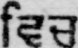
ਵਿਚ
